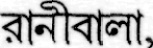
রানীবালা,
